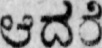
ಆದರೆ
